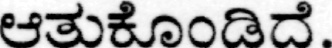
ಆತುಕೊಂಡಿದೆ.
